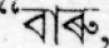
"বাৰু,
